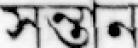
সন্তান
